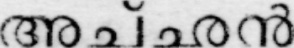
അച്ഛന്‍
